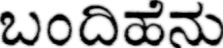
ಬಂದಿಹೆನು
